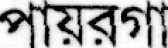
পায়রগা
